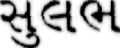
સુલભ
